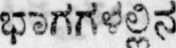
ಭಾಗಗಳಲ್ಲಿನ
